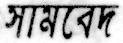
সামবেদ
